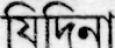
যিদিনা
